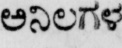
ಅನಿಲಗಳ
